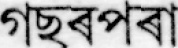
গছৰপৰা
